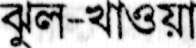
ঝুল-খাওয়া
